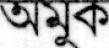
অমুক
